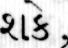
શકે,
